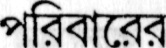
পরিবারের
